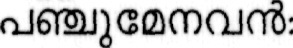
പഞ്ചുമേനവന്‍:
